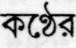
কণ্ঠের
